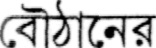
বৌঠানের
